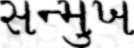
સન્મુખ
